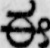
ಈ
